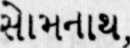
સોમનાથ,
